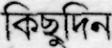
কিছুদিন
